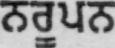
ਨਰੂਪਨ
